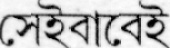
সেইবাবেই
